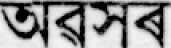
অৱসৰ
